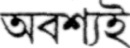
অবশ্যই
